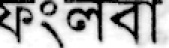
ফংলবা
